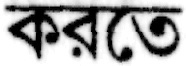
করতে
